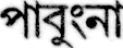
পাবুংনা
